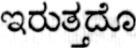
ಇರುತ್ತದೊ
